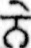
ਨੇ
